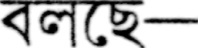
বলছে–
